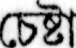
চেষ্টা
